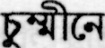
চুম্মীনে
